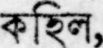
কহিল,
